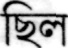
ছিল
